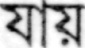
যায়
